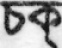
চক্
